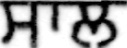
ਸਾਲ
